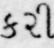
કરી
